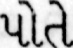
પોતે
